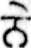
ਨੇ
